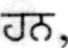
ਹਨ,
